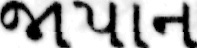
જાપાન
